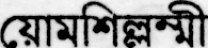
য়োমশিল্লম্মী
